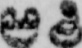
ಅತಿ
